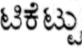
ಟಿಕೆಟ್ಟು
